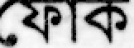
ফোক
